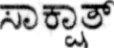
ಸಾಕ್ಷಾತ್
